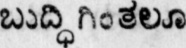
ಬುದ್ಧಿಗಿಂತಲೂ
